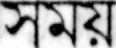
সময়
